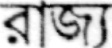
রাজ্য
